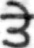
ਤੇ
